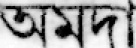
অমদা
